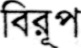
বিরূপ
